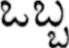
ಒಬ್ಬ
